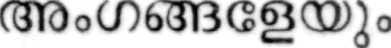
അംഗങ്ങളേയും
